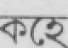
কহে
